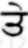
ਤੇ
